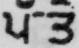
ਪੱਤੇ
